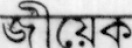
জীয়েক
